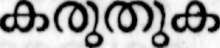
കരുതുക
